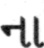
ન
